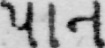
પાન
